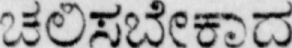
ಚಲಿಸಬೇಕಾದ
